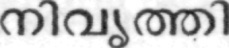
നിവൃത്തി
